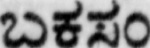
ಬಕಸಂ
